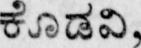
ಕೊಡವಿ,
